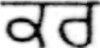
ਕਰ
